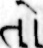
તો
